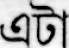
এটা
